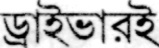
ড্রাইভারই
